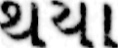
થયા
